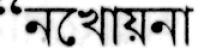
“নখোয়না
